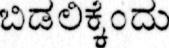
ಬಿಡಲಿಕ್ಕೆಂದು
